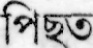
পিছত
